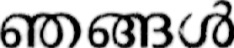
ഞങ്ങള്‍
